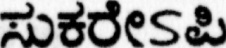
ಸುಕರೇsಪಿ
